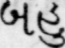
બહુ
